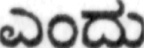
ಎಂದು
